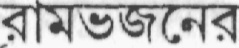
রামভজনের
